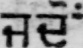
ਜਦੋਂ
